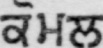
ਕੋਮਲ
